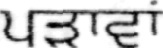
ਪੜਾਵਾਂ
